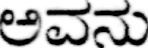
ಅವನು
